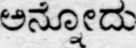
ಅನ್ನೋದು
